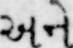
અને
